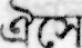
ঐসে
